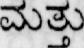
ಮತ್ತು
